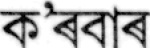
ক'ৰবাৰ
